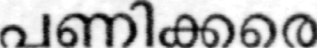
പണിക്കരെ
